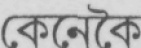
কেনেকৈ
